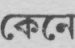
কেনে
